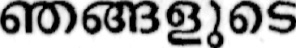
ഞങ്ങളുടെ
